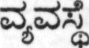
ವ್ಯವಸ್ಥೆ
